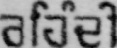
ਰਹਿੰਦੀ
